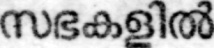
സഭകളില്‍
